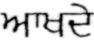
ਆਖਦੇ
